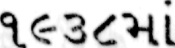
૧૯૩૮માં
